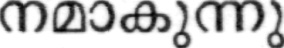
നമാകുന്നു
